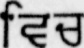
ਵਿਚ
